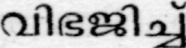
വിഭജിച്ച്
